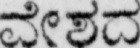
ವೇಶದ
